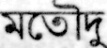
মতৌদু
